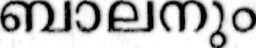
ബാലനും
